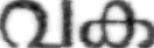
വക
